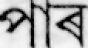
পাৰ
